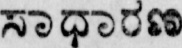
ಸಾಧಾರಣ
